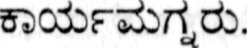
ಕಾರ್ಯಮಗ್ನರು.
